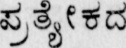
ಪ್ರತ್ಯೇಕದ
